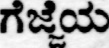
ಗೆಜ್ಜೆಯ
